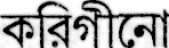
করিগীনো
